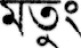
মতুং
